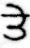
ਤੇ
